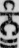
ਨੂੰ
